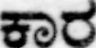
ಕಾರ
